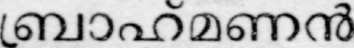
ബ്രാഹ്മണന്‍
